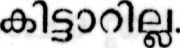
കിട്ടാറില്ല.
